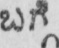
ಬಗ್ಗೆ
